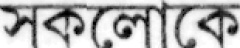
সকলোকে
